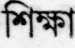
শিক্ষা
